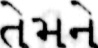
તેમને
